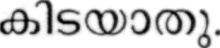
കിടയാതു.
